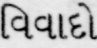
વિવાદો
